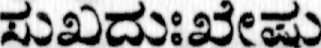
ಸುಖದುಃಖೇಷು
